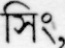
সিং,
